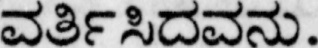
ವರ್ತಿಸಿದವನು.
